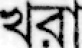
খরা
